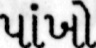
પાંખો
